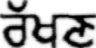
ਰੱਖਣ
